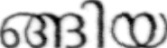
ങ്ങിയ
